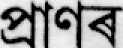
প্রাণৰ
